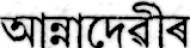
আন্নাদেৱীৰ
